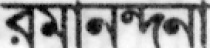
রমানন্দনা
